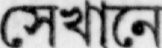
সেখানে
